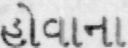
હોવાના
